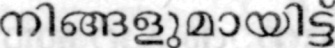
നിങ്ങളുമായിട്ട്
